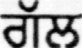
ਗੱਲ
